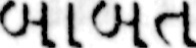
બાબત
